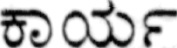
ಕಾಯ೯
